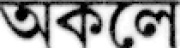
অকলে
